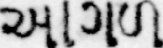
આગળ
